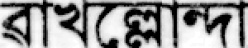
ৱাখল্লোন্দা
